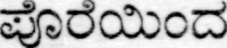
ಪೊರೆಯಿಂದ
